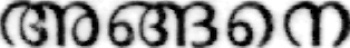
അങ്ങനെ
